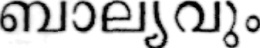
ബാല്യവും
